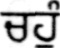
ਚਹੁੰ
